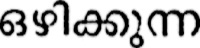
ഒഴിക്കുന്ന
